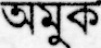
অমুক
